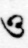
ও
